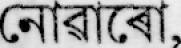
নোৱাৰো,
